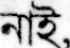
নাই,
